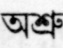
অশ্রু
